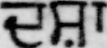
ਦਸ਼ਾ
